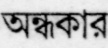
অন্ধকার
